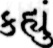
કહ્યું
